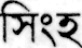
সিংহ
